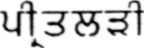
ਪ੍ਰੀਤਲੜੀ
